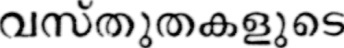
വസ്തുതകളുടെ
